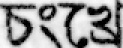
চংখ্রে
